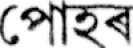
পোহৰ
